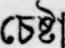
চেষ্টা
